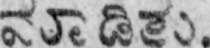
ಮಾಡಿತು.
